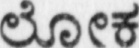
ಲೋಕ
